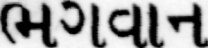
ભગવાન
